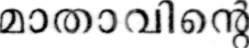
മാതാവിന്റെ
